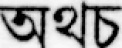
অথচ
